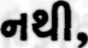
નથી,
